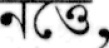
নত্তে,
